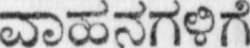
ವಾಹನಗಳಿಗೆ
